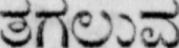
ತಗಲುವ
